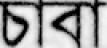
চাবা
